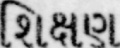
શિક્ષણ
